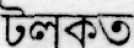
টলকত
